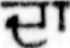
ਦਾ
